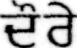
ਦੌਰੇ
